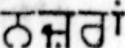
ਨਜ਼ਰਾਂ
